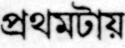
প্রথমটায়
